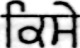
ਕਿਸੇ
